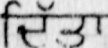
ਦਿੱਤਾ
